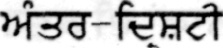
ਅੰਤਰ-ਦ੍ਰਿਸ਼ਟੀ
